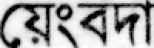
য়েংবদা
